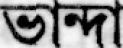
ভান্দা
